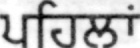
ਪਹਿਲਾਂ
